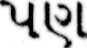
પણ
